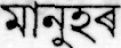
মানুহৰ
